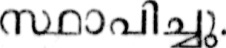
സ്ഥാപിച്ചു.
